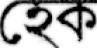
হেক
